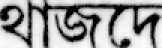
থাজদে
